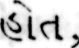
હોત,
